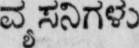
ವ್ಯಸನಿಗಳು
